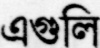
এগুলি
